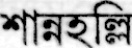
শান্নহল্লি
